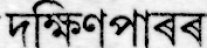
দক্ষিণপাৰৰ
